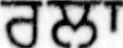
ਰਲਾ
